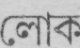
লোক
